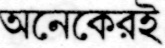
অনেকেরই
